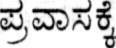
ಪ್ರವಾಸಕ್ಕೆ
